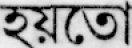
হয়তো
